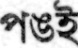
পঙই
